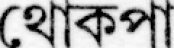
থোকপা
